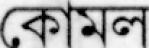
কোমল
